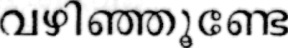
വഴിഞ്ഞുണ്ടേ
